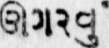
ઊગરવું
